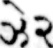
ઝેર
